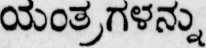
ಯಂತ್ರಗಳನ್ನು
